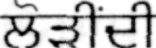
ਲੋੜੀਂਦੀ
